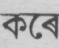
কৰে
